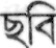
ছবি
